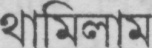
থামিলাম
